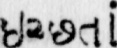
ઇચ્છતાં
